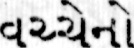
વચ્ચેનો
